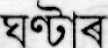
ঘণ্টাৰ
